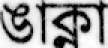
ঙাক্না
